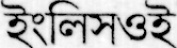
ইংলিসওই
